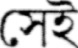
সেই
